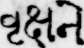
વૃક્ષને
